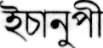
ইচানুপী
